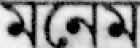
মনেম
